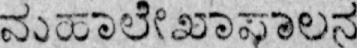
ಮಹಾಲೇಖಾಪಾಲನ
